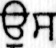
ਉਸ
